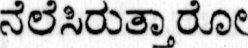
ನೆಲೆಸಿರುತ್ತಾರೋ
